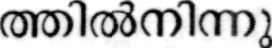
ത്തില്‍നിന്നു
